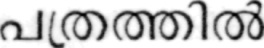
പത്രത്തില്‍
